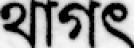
থাগৎ
